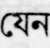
যেন
